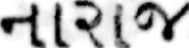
નારાજ
